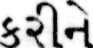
કરીને
